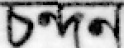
চন্দন
